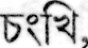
চংখি,
